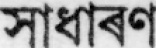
সাধাৰণ
